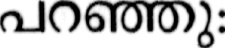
പറഞ്ഞു:
